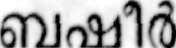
ബഷീര്‍
